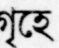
গৃহে
